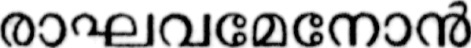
രാഘവമേനോന്‍
